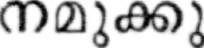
നമുക്കു
